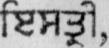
ਇਸਤ੍ਰੀ,
